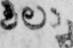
ಶಿಲ್ಕು
